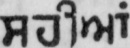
ਸਹੀਆਂ
